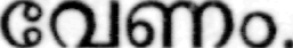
വേണം.
